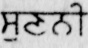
ਸੁਣਨੀ
